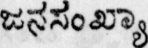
ಜನಸಂಖ್ಯಾ
